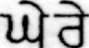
ਘੇਰੇ
